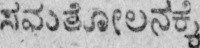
ಸಮತೋಲನಕ್ಕೆ
